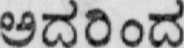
ಅದರಿಂದ
